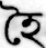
হৈ
